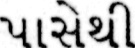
પાસેથી
